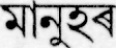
মানুহৰ
